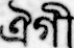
ঐগী
